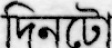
দিনটো
